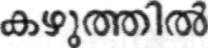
കഴുത്തില്‍
